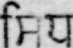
ਸਿਧ
